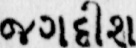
જગદીશ
